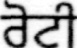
ਰੋਟੀ
